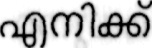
എനിക്ക്
